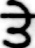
ਤੇ
